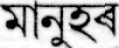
মানুহৰ
